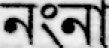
নংনা
